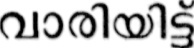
വാരിയിട്ട്
